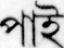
পাই
